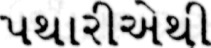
પથારીએથી
